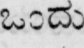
ಒಂದು
